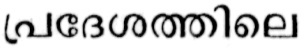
പ്രദേശത്തിലെ
